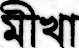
মীখা
